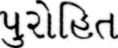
પુરોહિત
